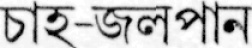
চাহ-জলপান
